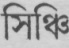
সিঞ্চি
